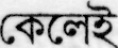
কেলেই
